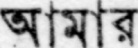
আমার
